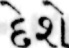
દેશે
